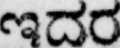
ಇದರ
